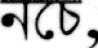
নচে,
